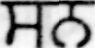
ਸਨ
